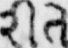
રીતે
